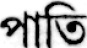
পাতি
